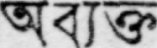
অব্যক্ত
